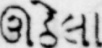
ઊઠેલા
